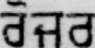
ਰੋਜਰ
